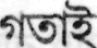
গতাই
